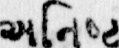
અનિષ્ટ
